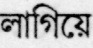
লাগিয়ে
